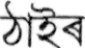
ঠাইৰ
